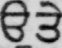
ਉਤੇ
